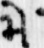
મેં
